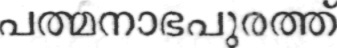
പത്മനാഭപുരത്ത്
